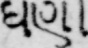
ઘણા
